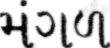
મંગળ
